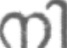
നി
